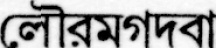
লৌরমগদবা
